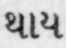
થાય
